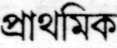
প্রাথমিক
